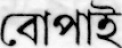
বোপাই
